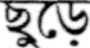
ছুড়ে
